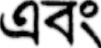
এবং
